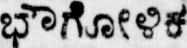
ಭೌಗೋಳಿಕ
